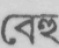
বেহু
